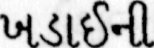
ખડાઈની
